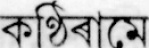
কণ্ঠিৰামে
